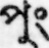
পুং
